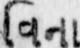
વિના
